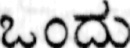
ಒಂದು
